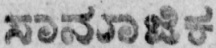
ಸಾಮಾಜಿಕ
